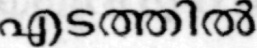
എടത്തില്‍
